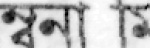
নখোয়
